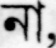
না,
